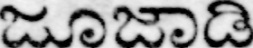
ಜೂಜಾಡಿ
